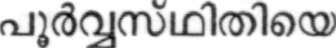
പൂര്‍വ്വസ്ഥിതിയെ
